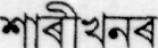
শাৰীখনৰ
